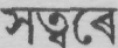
সত্বৰে
